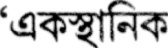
'একস্থানিক
